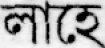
লাহে
